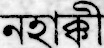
নহাক্কী
